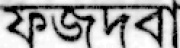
ফজদবা
